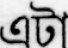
এটা
